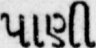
પાણી
